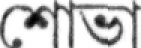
শোভা
